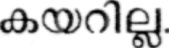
കയറില്ല.
